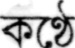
কণ্ঠে
